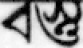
বস্তু
